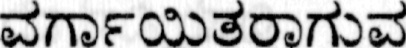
ವರ್ಗಾಯಿತರಾಗುವ
